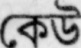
কেউ
